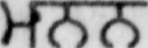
ਮਨਨ
